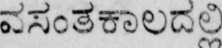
ವಸಂತಕಾಲದಲ್ಲಿ
